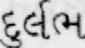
દુર્લભ
